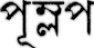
পূম্লপ
